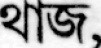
থাজ,
